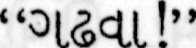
"ગઢવા!"
